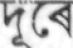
দূৰে
